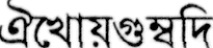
ঐখোয়গুম্বদি
